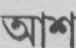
আশ
